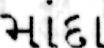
માંદા
